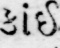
કાંઈ
